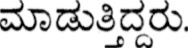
ಮಾಡುತ್ತಿದ್ದರು.
